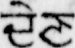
ਦੇਣ
